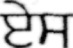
ਏਸ
